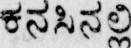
ಕನಸಿನಲ್ಲಿ
